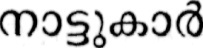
നാട്ടുകാര്‍
